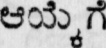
ಆಯ್ಕೆಗೆ
